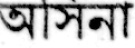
অসিনা
